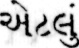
એટલું
